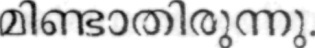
മിണ്ടാതിരുന്നു.
